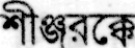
শীঞ্জরক্কে
